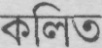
কলিত
